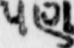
પણ
